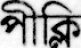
পীক্লি
